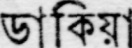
ডাকিয়া
